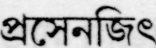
প্রসেনজিত্
